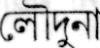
লৌদুনা
